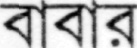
বাবার
